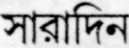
সারাদিন
